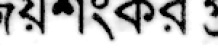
জয়শংকর
